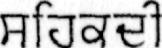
ਸਹਿਕਦੀ
